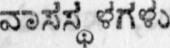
ವಾಸಸ್ಥಳಗಳು
